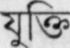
যুক্তি
